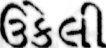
ઉકેલી
